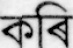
কৰি
